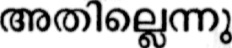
അതില്ലെന്നു
